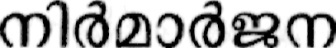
നിര്‍മാര്‍ജന
